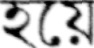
হয়ে
